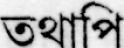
তথাপি
